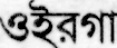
ওইরগা
